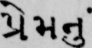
પ્રેમનું
